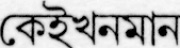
কেইখনমান
